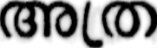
അത്ര
